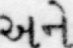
અને
